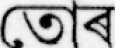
তোৰ
